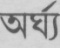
অৰ্ঘ্য
